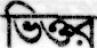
ভিক্তর
